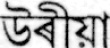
উৰীয়া
